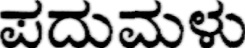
ಪದುಮಳು
